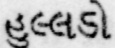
હુલ્લડો
